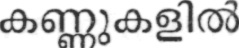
കണ്ണുകളില്‍
